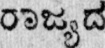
ರಾಜ್ಯದ
